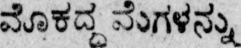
ಮೊಕದ್ದಮೆಗಳನ್ನು
